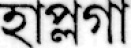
হাপ্লগা
